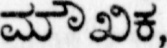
ಮೌಖಿಕ,
